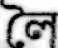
লৈ
